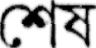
শেষ
